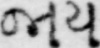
જાય
